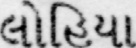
લોહિયા
